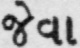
જેવા
